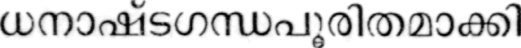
ധനാഷ്ടഗന്ധപൂരിതമാക്കി
